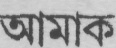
আমাক
